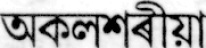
অকলশৰীয়া
